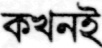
কখনই
